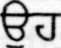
ਉਹ
